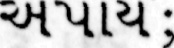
અપાય;
